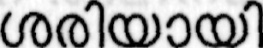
ശരിയായി
